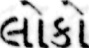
લોકો
